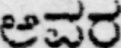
ಅವರ
